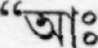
"আঃ
